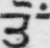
ਤੋਂ
